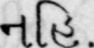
નહિ.
